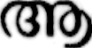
ആ
